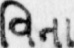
વિના
